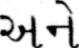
અને
